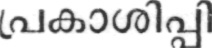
പ്രകാശിപ്പി
